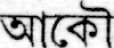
আকৌ
